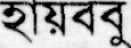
হায়ববু
